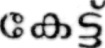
കേട്ട്
